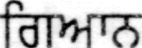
ਗਿਆਨ
